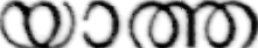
യാത്ത
